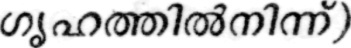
ഗൃഹത്തില്‍നിന്ന്)
